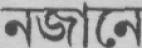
নজানে
